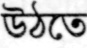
উঠতে
